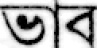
ভাব
